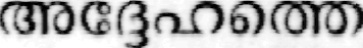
അദ്ദേഹത്തെ
